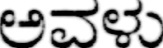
ಅವಳು
